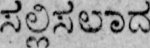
ಸಲ್ಲಿಸಲಾದ
